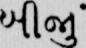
બીજું
